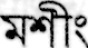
মশীং
